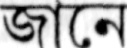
জানে
